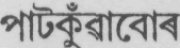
পাটকুঁৱাবোৰ
